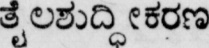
ತೈಲಶುದ್ಧೀಕರಣ
